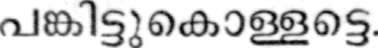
പങ്കിട്ടുകൊള്ളട്ടെ.
